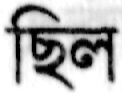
ছিল
